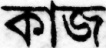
কাজ
